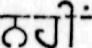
ਨਹੀਂ
